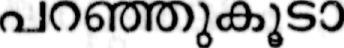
പറഞ്ഞുകൂടാ
